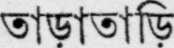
তাড়াতাড়ি
